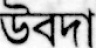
উবদা
